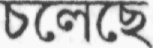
চলেছে
